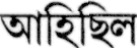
আহিছিল
